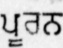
ਪੂਰਨ
